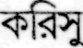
করিসু
